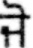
ਜੋ
